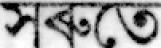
সৰুতে
